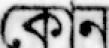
কোন
